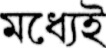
মধ্যেই
